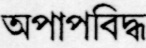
অপাপবিদ্ধ
